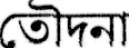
তৌদনা
